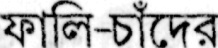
ফালি-চাঁদের
